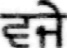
ਵਜੇ
